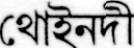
থোইনদী
